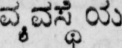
ವ್ಯವಸ್ಥೆಯ
